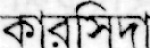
কারসিদা
